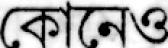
কোনেও
